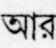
আর
